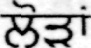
ਲੋੜਾਂ
